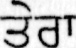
ਤੇਰਾ
